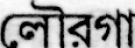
লৌরগা
